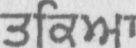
ਤਕਿਆ
